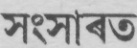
সংসাৰত
